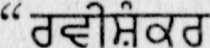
''ਰਵੀਸ਼ੰਕਰ
